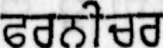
ਫਰਨੀਚਰ
